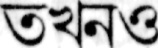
তখনও
